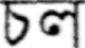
চল
